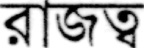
রাজত্ব
